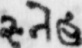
સ્નેહ
